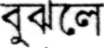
বুঝলে
